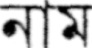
নাম
